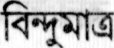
বিন্দুমাত্র
